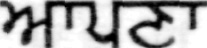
ਆਪਣਾ
